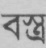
বস্ত্ৰ
